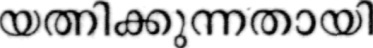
യത്നിക്കുന്നതായി
